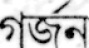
গর্জন
